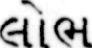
લોભ
